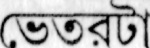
ভেতরটা
